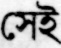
সেই
